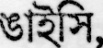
ঙাইসি,
